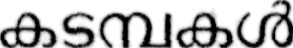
കടമ്പകള്‍
